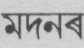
মদনৰ
